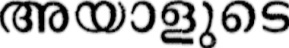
അയാളുടെ
